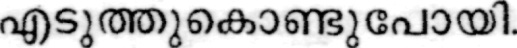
എടുത്തുകൊണ്ടുപോയി.
